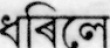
ধৰিলে
